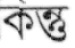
কিন্তু
